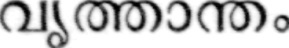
വൃത്താന്തം
